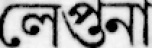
লেপ্তনা
